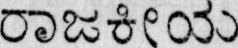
ರಾಜಕೀಯ
